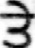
ਤੇ
